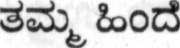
ತಮ್ಮಹಿಂದೆ
